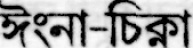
ঈংনা-চিক্না
